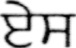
ਏਸ
